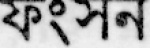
ফংসন
